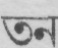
তন
